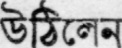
উঠিলেন
